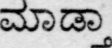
ಮಾಡ್ತಾ
